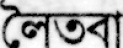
লৈতবা
